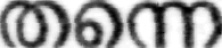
തന്നെ
